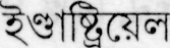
ইণ্ডাষ্ট্ৰিয়েল
